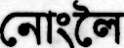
নোংলৈ
